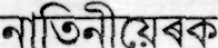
নাতিনীয়েৰক
